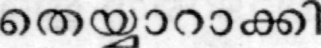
തെയ്യാറാക്കി
